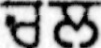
ਚਲ
